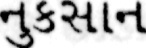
નુકસાન
